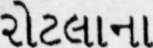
રોટલાના
